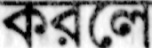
করলে
